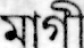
মাগী
